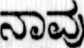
ನಾವು
